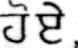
ਹੋਏ,
